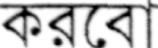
করবো
